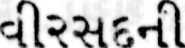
વીરસદની
